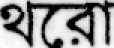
থরো
